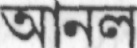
আনল
